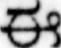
ಈ
